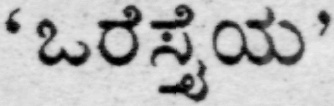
ಮುಂದಿನ
